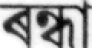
ৰন্ধা
